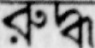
রুদ্ধ
